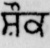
ਸ਼ੌਕ
